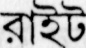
রাইট
